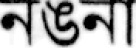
নঙনা
